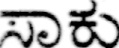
ಸಾಕು
